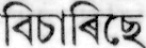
বিচাৰিছে
